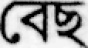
বেছ
